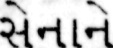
સેનાને
